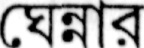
ঘেন্নার
